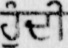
ਹੁੰਦੀ
